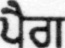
ਪੈਗ
